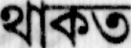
থাকত
